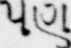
પણ
